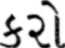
કરો
